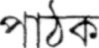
পাঠক
